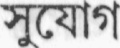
সুযোগ
